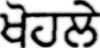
ਖੋਹਲੇ
